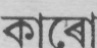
কাৰো
